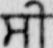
ਸੀ
